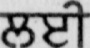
ਲਈ
